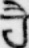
ਹੈ
